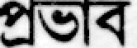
প্রাভাব
